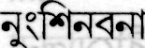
নুংশিনবনা
